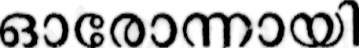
ഓരോന്നായി
